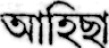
আহিছা
